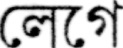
লেগে
